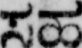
ಸಹ
